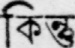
কিন্তু
